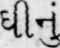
ઘીનું
